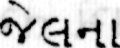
જેલના
